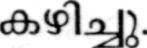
കഴിച്ചു.
